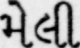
મેલી
